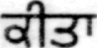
ਕੀਤਾ
